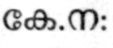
കേ.ന:
